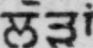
ਲੋੜਾਂ
